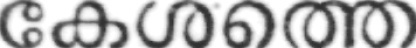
കേശത്തെ
